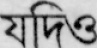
যদিও
